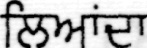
ਲਿਆਂਦਾ
